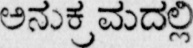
ಅನುಕ್ರಮದಲ್ಲಿ
